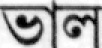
ভাল
